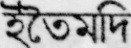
ইতৈমদি
